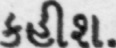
કહીશ.
